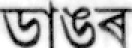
ডাঙৰ
